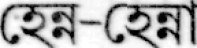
হেন্না-হেন্না
